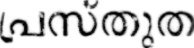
പ്രസ്തുത
